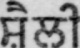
ਸ਼ੈਲੀ
